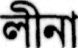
লীনা
